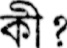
কী?
